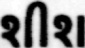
શીશ
